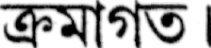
ক্রমাগত।
